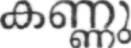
കണ്ണു
